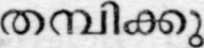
തമ്പിക്കു
